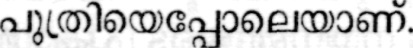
പുത്രിയെപ്പോലെയാണ്.
